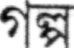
গল্প
